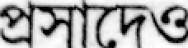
প্রসাদেও
